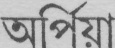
অর্পিয়া
